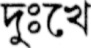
দুঃখে
